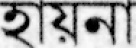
হায়না
